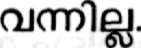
വന്നില്ല.
